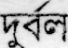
দুর্বল
